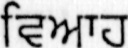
ਵਿਆਹ
